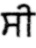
ਸੀ
